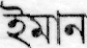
ইমান
